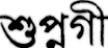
শুপ্নগী
